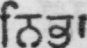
ਨਿਭਾ
